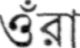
ওঁরা
